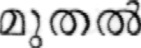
മുതല്‍
